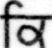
ਕਿ
